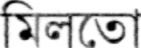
মিলতো
